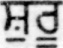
ਸ਼ੁਰੂ
